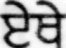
ਏਥੇ
